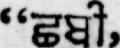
''ਛਬੀ,
